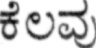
ಕೆಲವು
